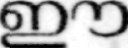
ഈ
